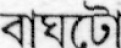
বাঘটো
